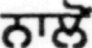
ਨਾਲੋਂ
